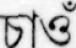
চাওঁ
